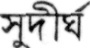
সুদীর্ঘ
